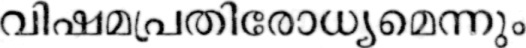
വിഷമപ്രതിരോധ്യമെന്നും
